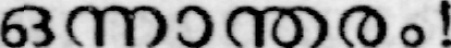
ഒന്നാന്തരം!
